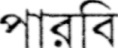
পারবি
